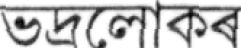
ভদ্রলোকৰ
